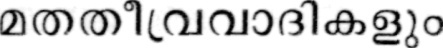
മതതീവ്രവാദികളും
